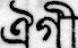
ঐগী
